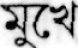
মুখে
